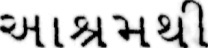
આશ્રમથી
